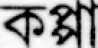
কপ্পা
